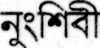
নুংশিবী
